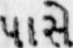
પાસે
